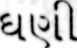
ઘણી
